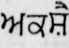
ਅਕਸ਼ੈ
